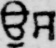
ਉਸ
